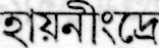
হায়নীংদ্রে
